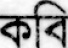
কবি
